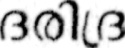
ദരിദ്ര
